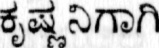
ಕೃಷ್ಣನಿಗಾಗಿ
